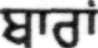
ਬਾਰਾਂ
